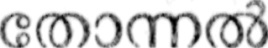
തോന്നല്‍
